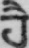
ਹੈ
